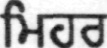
ਮਿਹਰ
